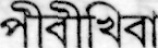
পীবীখিবা
